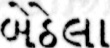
બેઠેલા
